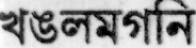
খঙলমগনি
